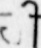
ਹੀ
